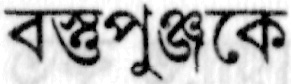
বস্তুপুঞ্জকে
